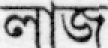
লাজ
